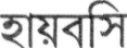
হায়বসি
